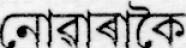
নোৱাৰাকৈ
